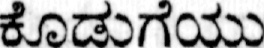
ಕೊಡುಗೆಯು
